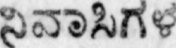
ನಿವಾಸಿಗಳ
